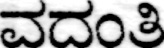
ವದಂತಿ
